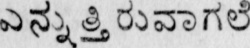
ಎನ್ನುತ್ತಿರುವಾಗಲೆ
